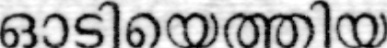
ഓടിയെത്തിയ
